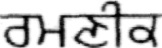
ਰਮਣੀਕ
